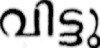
വിട്ടു
